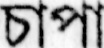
চাপা
